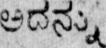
ಅದನ್ನು
